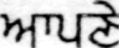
ਆਪਣੇ
